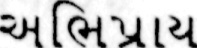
અભિપ્રાય
